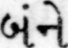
બંને
